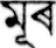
মূৰ
